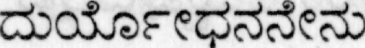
ದುರ್ಯೋಧನನೇನು
